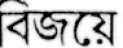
বিজয়ে
